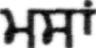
ਮਸਾਂ
